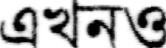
এখনও
